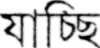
যাচ্ছি
